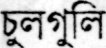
চুলগুলি
